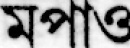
মপাও
